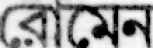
রোমেন
